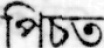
পিচত
